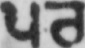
ਪਰ
